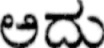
ಅದು
